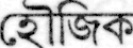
হৌজিক
